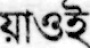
য়াওই
